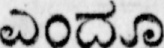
ಎಂದೂ
